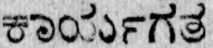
ಕಾರ್ಯಗತ
